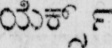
ಯೆರ್ಕ್ಸ್
